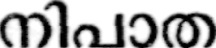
നിപാത
